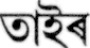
তাইৰ
